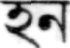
হন
